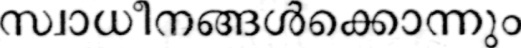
സ്വാധീനങ്ങള്‍ക്കൊന്നും
